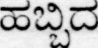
ಹಬ್ಬಿದ
